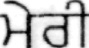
ਮੇਰੀ
